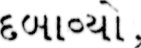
દબાવ્યો,
